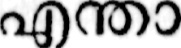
എന്താ
